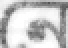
নে
